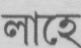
লাহে
